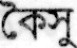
কৈসু
